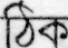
ঠিক
